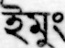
ইমুং
